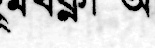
অহূমখক্না
